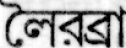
লৈরব্রা
